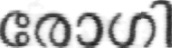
രോഗി
